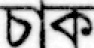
চাক
